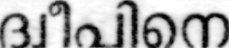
ദ്വീപിനെ
